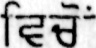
ਵਿਚੋਂ
